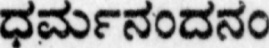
ಧರ್ಮನಂದನಂ
